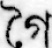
গৈ
